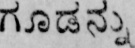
ಗೂಡನ್ನು
